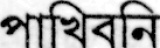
পাখিবনি
